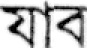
যাব
